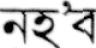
নহ'ব
